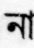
না
